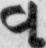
વ
